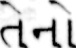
તેનો
